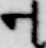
ન
